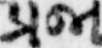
પ્રજા
